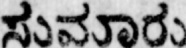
ಸುಮಾರು
